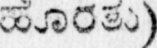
ಹೊರತು)
